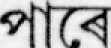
পাৰে
